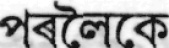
পৰলৈকে
